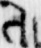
તો
